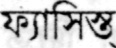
ফ্যাসিস্ত্
